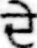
ਦੇ
